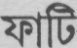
ফাটি
